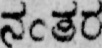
ನಂತರ
